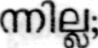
ന്നില്ല;
